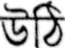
উঠি
